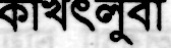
কাখৎলুবা
